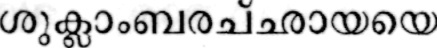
ശുക്ലാംബരച്ഛായയെ
